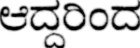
ಆದ್ದರಿಂದ
